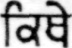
ਕਿਥੇ
